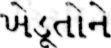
ખેડૂતોને
